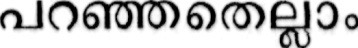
പറഞ്ഞതെല്ലാം
